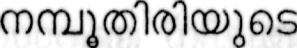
നമ്പൂതിരിയുടെ
